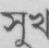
সুখ
